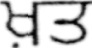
ਖ਼ਤ
